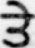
ਤੇ
